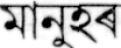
মানুহৰ
